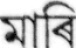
মাৰি
